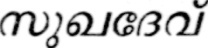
സുഖദേവ്
